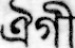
ঐগী
